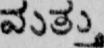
ಮತ್ತು
